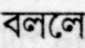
বললে
